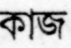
কাজ
